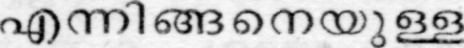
എന്നിങ്ങനെയുള്ള
